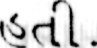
હતી.
